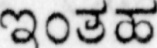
ಇಂತಹ
